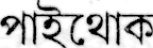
পাইথোক
